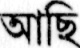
আছি
